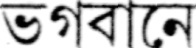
ভগবানে
